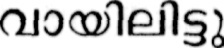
വായിലിട്ടു
